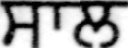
ਸਾਲ
